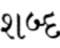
શબ્દ
